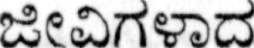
ಜೀವಿಗಳಾದ
